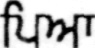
ਪਿਆ
